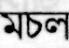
মচল
